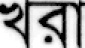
খরা
